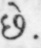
છે.
